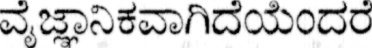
ವೈಜ್ಞಾನಿಕವಾಗಿದೆಯೆಂದರೆ
